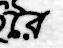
ইরৈ
